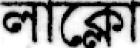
লাক্লো
